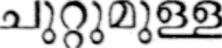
ചുറ്റുമുള്ള
